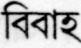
বিবাহ
